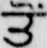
ਤੋਂ
